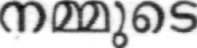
നമ്മുടെ
